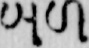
બળ
